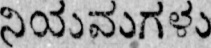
ನಿಯಮಗಳು
